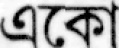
একো
